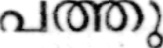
പത്തു
